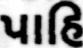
પાહિ
